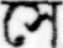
সে
